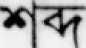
শব্দ
